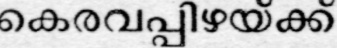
കെരവപ്പിഴയ്ക്ക്
